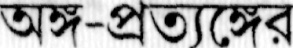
অঙ্গ-প্রত্যঙ্গের
